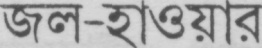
জল-হাওয়ার
